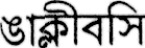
ঙাক্লীবসি
